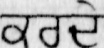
ਕਰਦੇ
